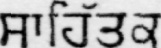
ਸਾਹਿੱਤਕ
